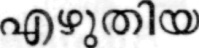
എഴുതിയ
